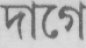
দাগে
